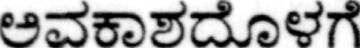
ಅವಕಾಶದೊಳಗೆ
